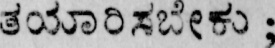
ತಯಾರಿಸಬೇಕು;
